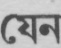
যেন
